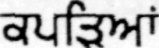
ਕਪੜਿਆਂ
